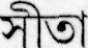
সীতা
